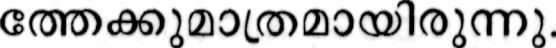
ത്തേക്കുമാത്രമായിരുന്നു.
